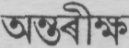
অন্তৰীক্ষ
